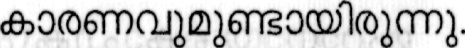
കാരണവുമുണ്ടായിരുന്നു.
